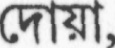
দোয়া,
